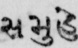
સમુહે
